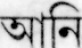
আনি
